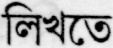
লিখতে
